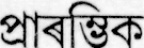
প্রাৰম্ভিক
